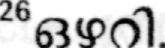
26ഒഴറി.
